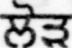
ਲੋੜ
